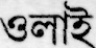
ওলাই
